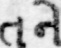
તને
